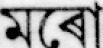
মৰো
